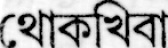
থোকখিবা
